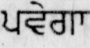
ਪਵੇਗਾ
